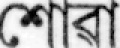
শোৱা
